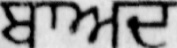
ਬਾਅਦ
